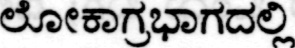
ಲೋಕಾಗ್ರಭಾಗದಲ್ಲಿ
